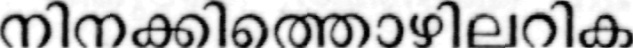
നിനക്കിത്തൊഴിലറിക
